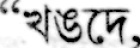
“খঙদে,
